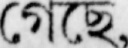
গেছে,
